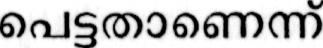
പെട്ടതാണെന്ന്
